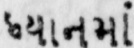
ધ્યાનમાં
